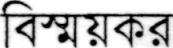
বিস্ময়কর
